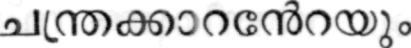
ചന്ത്രക്കാറന്റേയും
